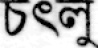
চৎলু
